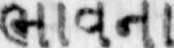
ભાવના
